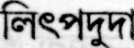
লিৎপদুদা
